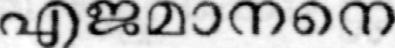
എജമാനനെ
